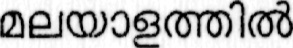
മലയാളത്തില്‍
